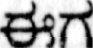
ಈಗ
